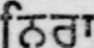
ਨਿਰਾ
